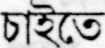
চাইতে
